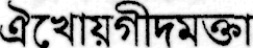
ঐখোয়গীদমক্তা
